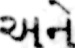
અને
